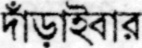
দাঁড়াইবার
